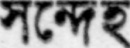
সন্দেহ
